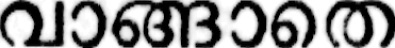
വാങ്ങാതെ
